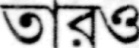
তারও
